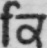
ਕਿ
